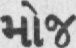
મોજ
